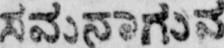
ಸಮನಾಗುವ
